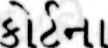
કાર્ટના
